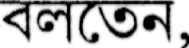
বলতেন,
